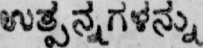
ಉತ್ಪನ್ನಗಳನ್ನು
